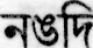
নঙদি
